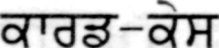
ਕਾਰਡ-ਕੇਸ
